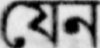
যেন
